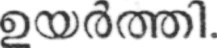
ഉയര്‍ത്തി.
